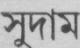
সুদাম
